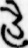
હૈ
